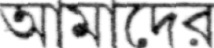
আমাদের
